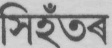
সিহঁতৰ
